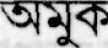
অমুক
